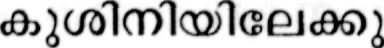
കുശിനിയിലേക്കു
